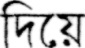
দিয়ে
